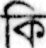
কি
